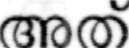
അത്
